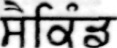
ਸੈਕਿੰਡ
